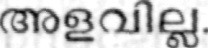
അളവില്ല.
